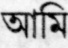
আমি
